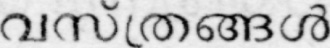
വസ്ത്രങ്ങള്‍
